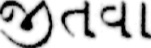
જીતવા
